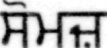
ਸੋਮਜ਼
